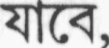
যাবে,
